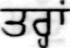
ਤਰ੍ਹਾਂ
